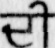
ਦੀ
